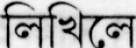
লিখিলে
